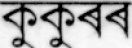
কুকুৰৰ
